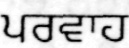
ਪਰਵਾਹ
